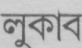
লুকাব
